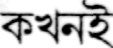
কখনই
